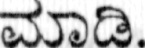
ಮಾಡಿ.
